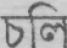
চলি
